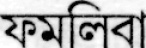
ফমলিবা
